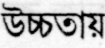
উচ্চতায়
